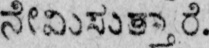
ನೇಮಿಸುತ್ತಾರೆ.
